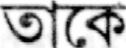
তাকে
